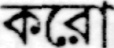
করো
